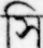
সি
